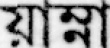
য়াম্না
